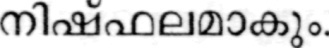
നിഷ്ഫലമാകും.
